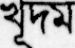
খূদম
